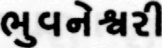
ભુવનેશ્વરી
